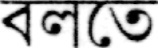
বলতে
